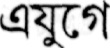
এযুগে
